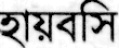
হায়বসি
